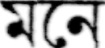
মনে
